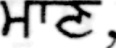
ਮਾਣ,
